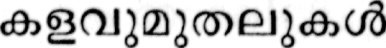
കളവുമുതലുകള്‍
